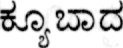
ಕ್ಯೂಬಾದ
